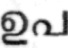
ഉപ
